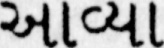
આવ્યા
